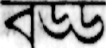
বড্ড
